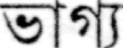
ভাগ্য
